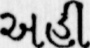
અહીં
